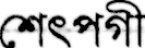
শেৎপগী
